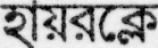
হায়রক্লে
